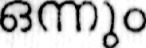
ഒന്നും
